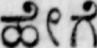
ಹೇಗೆ
